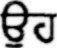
ਉਹ
